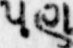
પણ
